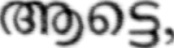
ആട്ടെ,
